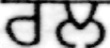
ਰਲ
